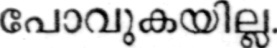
പോവുകയില്ല.
